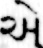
એ
